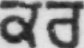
ਕਰ
